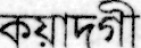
কয়াদগী
